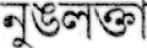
নুঙলক্তা
